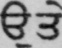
ਉਤੇ
